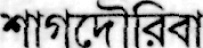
শাগদৌরিবা
